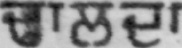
ਢਾਲਦਾ
